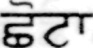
ਛੋਟਾ
